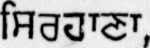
ਸਿਰਹਾਣਾ,
